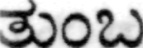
ತುಂಬ
